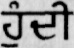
ਹੁੰਦੀ
